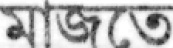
মাজতে
